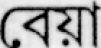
বেয়া
